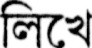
লিখে
